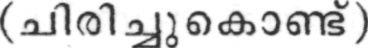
(ചിരിച്ചുകൊണ്ട്)
